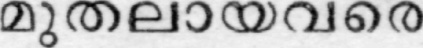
മുതലായവരെ
